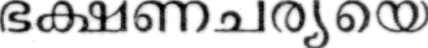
ഭക്ഷണചര്യയെ
